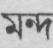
মন্দ
